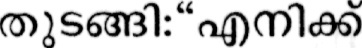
തുടങ്ങി:“എനിക്ക്
